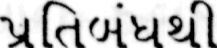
પ્રતિબંધથી
